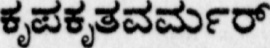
ಕೃಪಕೃತವರ್ಮರ್
